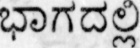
ಭಾಗದಲ್ಲಿ
